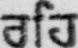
ਰਹਿ
